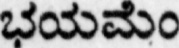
ಭಯಮೆಂ
